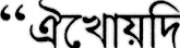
“ঐখোয়দি
